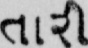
તારી
